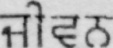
ਜੀਵਨ
